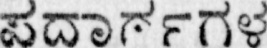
ಪದಾರ್ಥಗಳ
